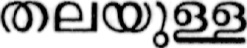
തലയുള്ള
